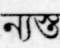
ন্যস্ত
